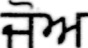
ਜੋਅ
